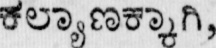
ಕಲ್ಯಾಣಕ್ಕಾಗಿ,
